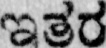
ಇತರ
